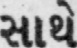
સાથે
